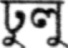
ঢুলু
